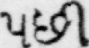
પછી
